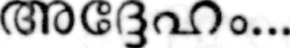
അദ്ദേഹം...
